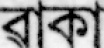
ৱাকা
